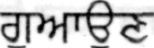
ਗੁਆਉਣ
